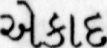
એકાદ
